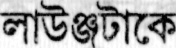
লাউঞ্জটাকে
